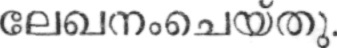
ലേഖനംചെയ്തു.
